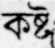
কষ্ট
